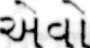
એવો
